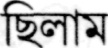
ছিলাম
